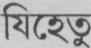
যিহেতু
